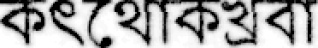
কৎথোকখ্রবা
